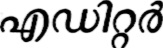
എഡിറ്റര്‍
